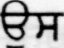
ਉਸ
